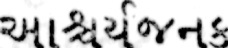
આશ્ચર્યજનક
